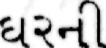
ઘરની
